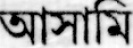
আসামি
